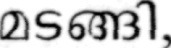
മടങ്ങി,
